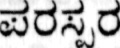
ಪರಸ್ಪರ
